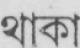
থাকা
